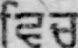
ਵਿਚ
